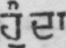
ਹੁੰਦਾ
